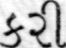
કરી
